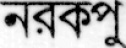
নরকপু
